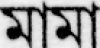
মামা
